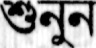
শুনুন
